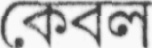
কেবল
